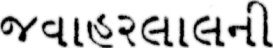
જવાહરલાલની
